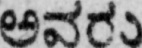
ಅವರು
